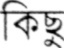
কিছু
